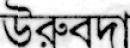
উরুবদা
